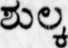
ಶುಲ್ಕ
